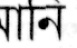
মানি
